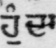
ਹੁੰਦਾ
